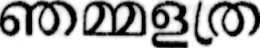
ഞമ്മളത്ര
